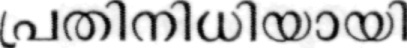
പ്രതിനിധിയായി
